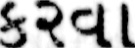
કરવા
